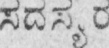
ಸದಸ್ಯರ
